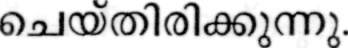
ചെയ്തിരിക്കുന്നു.
